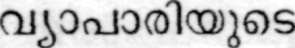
വ്യാപാരിയുടെ
